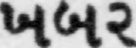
ખબર
